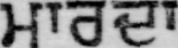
ਮਾਰਦਾ
